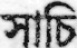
সাচি
